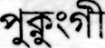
পুক্নুংগী
